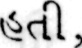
હતી,પણ
